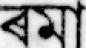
ৰমা
